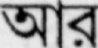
আর
